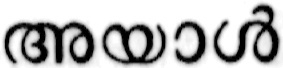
അയാള്‍
